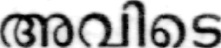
അവിടെ
